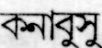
কনাবুসু
